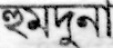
হুমদুনা
